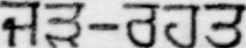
ਜੜ-ਰਹਤ
